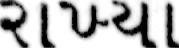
રાખ્યા
